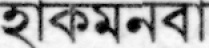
হাকমনবা
